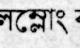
লম্লোং
